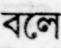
বলে
